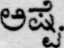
ಅಷ್ಟೆ.
